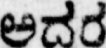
ಅದರ
